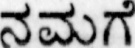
ನಮಗೆ
